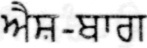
ਐਸ਼-ਬਾਗ
